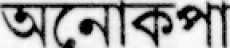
অনোকপা
